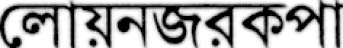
লোয়নজরকপা
